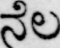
ನೆಲ
